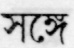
সঙ্গে
